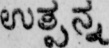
ಉತ್ಪನ್ನ
